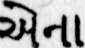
એના
